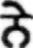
ਨੇ
